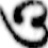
ও
